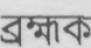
ব্ৰহ্মক
